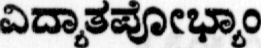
ವಿದ್ಯಾತಪೋಭ್ಯಾಂ
